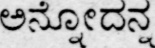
ಅನ್ನೋದನ್ನ
